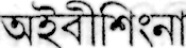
অইবীশিংনা
